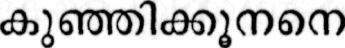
കുഞ്ഞിക്കൂനനെ
